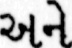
અને
